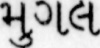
મુગલ
